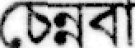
চেন্নবা
